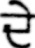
ਦੇ
